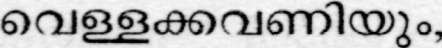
വെള്ളക്കവണിയും,
